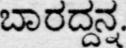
ಬಾರದ್ದನ್ನ.
